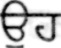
ਉਹ
